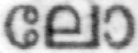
ലോ
